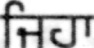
ਜਿਹਾ
